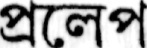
প্রলেপ
